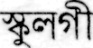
স্কুলগী
